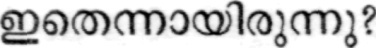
ഇതെന്നായിരുന്നു?
